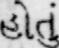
હોતું
